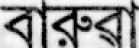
বারুৱা
